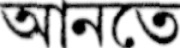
আনতে
